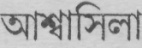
আশ্বাসিলা
